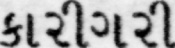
કારીગરી
